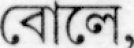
বোলে,
